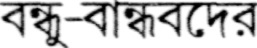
বন্ধু-বান্ধবদের
